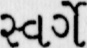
સ્વર્ગે
